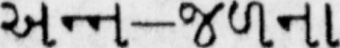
અન્ન-જળના
